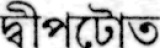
দ্বীপটোত
